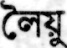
লৈয়ু
